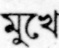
মুখে
